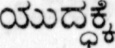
ಯುದ್ಧಕ್ಕೆ
